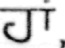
ਹਾਂ,
